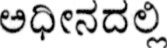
ಅಧೀನದಲ್ಲಿ
